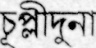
চূপ্নীদুনা
